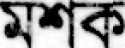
মশক
